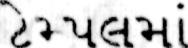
ટેમ્પલમાં
